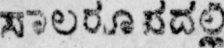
ಸಾಲರೂಪದಲ್ಲಿ
